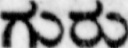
ಗುರು
